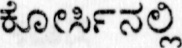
ಕೋರ್ಸಿನಲ್ಲಿ
